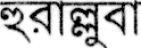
হুরাল্লুবা
